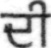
ਦੀ
